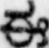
ಈ
